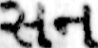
સન
